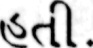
હતી.
